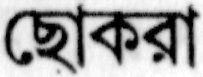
ছোকরা
